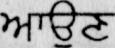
ਆਉਣ
